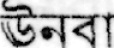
উনবা
